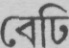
বেঢ়ি
